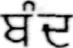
ਬੰਦ
